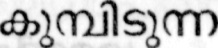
കുമ്പിടുന്ന
